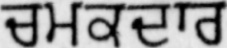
ਚਮਕਦਾਰ
